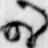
જે
